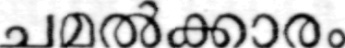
ചമല്‍ക്കാരം
